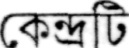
কেন্দ্রটি
